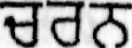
ਚਰਨ
